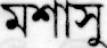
মশাসু
